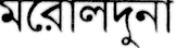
মরোলদুনা
